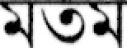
মতম
